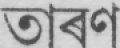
তাৰণ
